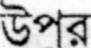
উপর
